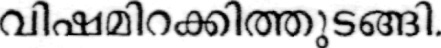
വിഷമിറക്കിത്തുടങ്ങി.
